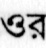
ওর
